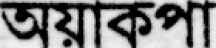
অয়াকপা
